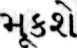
મૂકશે
